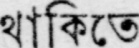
থাকিতে
